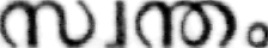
സ്വന്തം
